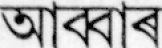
আব্বাৰ
